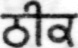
ਠੀਕ
